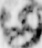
છે
